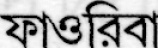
ফাওরিবা
